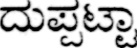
ದುಪ್ಪಟ್ಟಾ
